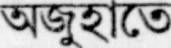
অজুহাতে
